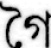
গৈ
